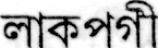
লাকপগী
